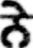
ਨੇ
